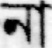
না
